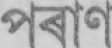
পৰাণ
